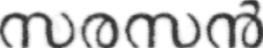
സരസന്‍
